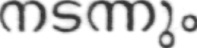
നടന്നും
